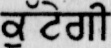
ਕੁੱਟੇਗੀ
